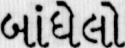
બાંઘેલો
